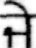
ਜੇ
